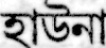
হাউনা
